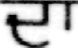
ਦਾ
